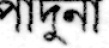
পাদুনা
